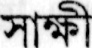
সাক্ষী
